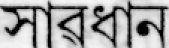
সাৱধান
